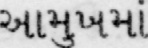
આમુખમાં
